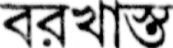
বরখাস্ত
